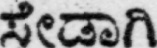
ಸೇಡಾಗಿ
